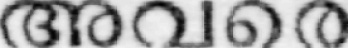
അവരെ
